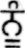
ਨੂੰ
